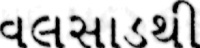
વલસાડથી
